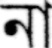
না
